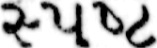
સ્પષ્ટ
